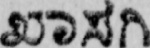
ಖಾಸಗಿ
